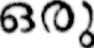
ഒരു
